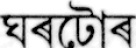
ঘৰটোৰ
